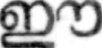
ഈ
